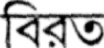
বিরত
